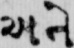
અને
